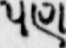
પણ
